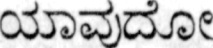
ಯಾವುದೋ
